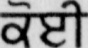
ਕੋਈ
